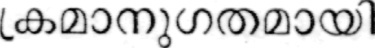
ക്രമാനുഗതമായി
